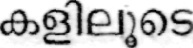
കളിലൂടെ
